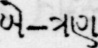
બે-ત્રણ
